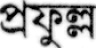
প্রফুল্ল
